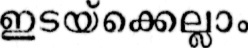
ഇടയ്ക്കെല്ലാം
